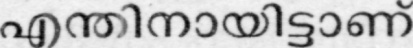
എന്തിനായിട്ടാണ്
